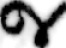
જ
